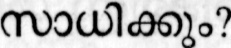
സാധിക്കും?
